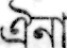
ঐনা
